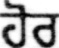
ਹੋਰ
